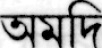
অমদি
